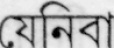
যেনিবা
